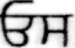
ਓਸ
